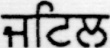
ਜਟਿਲ
